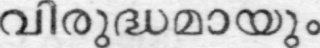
വിരുദ്ധമായും
